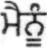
ਮੈਨੂੰ
